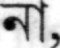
না,
